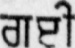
ਗਈ
